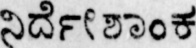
ನಿರ್ದೇಶಾಂಕ
